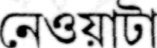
নেওয়াটা
